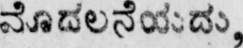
ಮೊದಲನೆಯದು,
